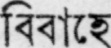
বিবাহে
